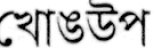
খোঙউপ
